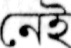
নেই
